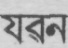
যৱন
